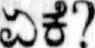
ಏಕೆ?
